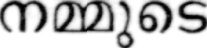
നമ്മുടെ
